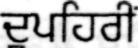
ਦੁਪਹਿਰੀਂ
